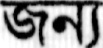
জন্য
